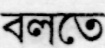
বলতে
